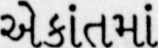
એકાંતમાં
